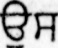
ਉਸ
